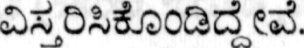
ವಿಸ್ತರಿಸಿಕೊಂಡಿದ್ದೇವೆ.
